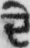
ਦੇ
